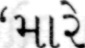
'મારે
